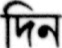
দিন
